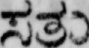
ಸತು
